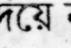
দয়ে
